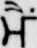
ਮੈਂ
